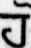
ਹੋ
